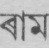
ৰাম
